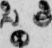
ಸ್ಥಿತಿ
